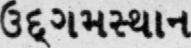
ઉદ્ગમસ્થાન
